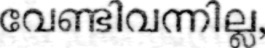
വേണ്ടിവന്നില്ല,
